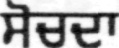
ਸੋਚਦਾ
